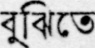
বুঝিতে
